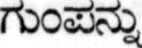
ಗುಂಪನ್ನು
